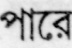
পারে
